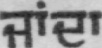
ਜਾਂਦਾ
